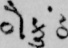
વૈકુંઠ
